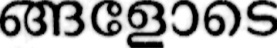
ങ്ങളോടെ
